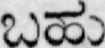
ಬಹು
